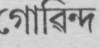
গোৱিন্দ
